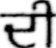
ਦੀ
